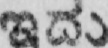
ಇದು
